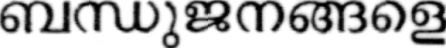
ബന്ധുജനങ്ങളെ
